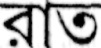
রাত
